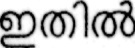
ഇതില്‍
